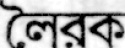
লৈরক
